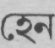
হেন
